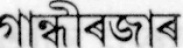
গান্ধীৰজাৰ
